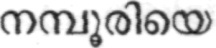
നമ്പൂരിയെ
